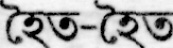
হৈত-হৈত
